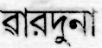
ৱারদুনা
